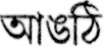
আঙঠি
